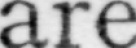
are
